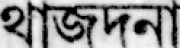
থাজদনা
